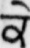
ਕੇ
